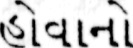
હોવાનો
